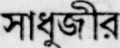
সাধুজীর
